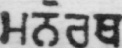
ਮਨੋਰਥ
